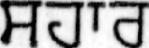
ਸਹਾਰ
